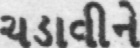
ચડાવીને
